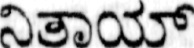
ನಿತಾಯ್
